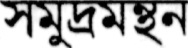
সমুদ্রমন্থন
